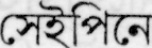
সেইপিনে
